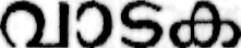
വാടക
